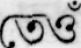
তেওঁ
